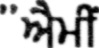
''ਐਮੀਂ
